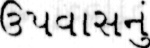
ઉપવાસનું
